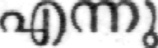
എന്നു
